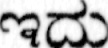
ಇದು
